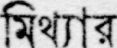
মিথ্যার
